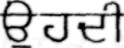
ਉਹਦੀ
